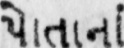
પોતાનાં
